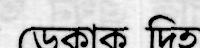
ডেকাকা
